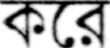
করে
